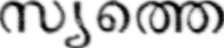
സ്യത്തെ
